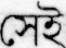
সেই
